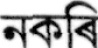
নকৰি
